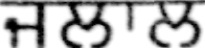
ਜਲਾਲ
